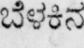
ಬೆಳಕಿನ
